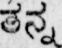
ತನ್ನ
